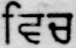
ਵਿਚ
